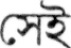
সেই
